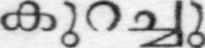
കുറച്ചു
